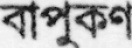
বাপুকণ
